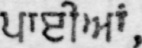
ਪਾਈਆਂ,
